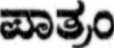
ಪಾತ್ರಂ
